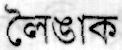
লৈঙাক
